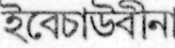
ইবেচাউবীনা
